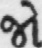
જો
